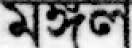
মঙ্গল
